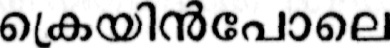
ക്രെയിന്‍പോലെ
